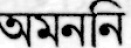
অমননি
